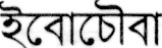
ইবোচৌবা
